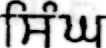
ਸਿੰਘ
